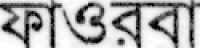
ফাওরবা
